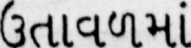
ઉતાવળમાં
